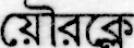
য়ৌরক্লে
